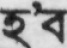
হ'ব
